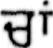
ਚਾਂ
